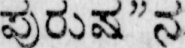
ಪುರುಷ”ನ
